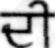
ਦੀ
